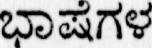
ಭಾಷೆಗಳ
